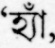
‘হ্যাঁ,
